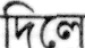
দিলে
